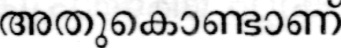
അതുകൊണ്ടാണ്
